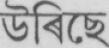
উৰিছে
